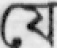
যে
